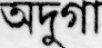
অদুগা
